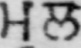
ਮੁਲ
